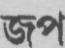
জপ
